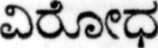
ವಿರೋಧ
